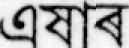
এষাৰ
